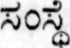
ಸಂಸ್ಥೆ
